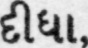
દીધા,
